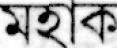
মহাক
